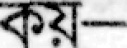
কয়-
